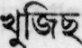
খুজিছ
